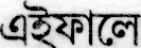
এইফালে
